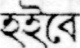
হইবে
